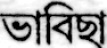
ভাবিছা
